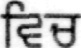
ਵਿਚ
